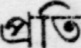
প্রতি
